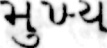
મુખ્ય
